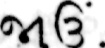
જાઉં.
